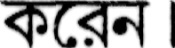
করেন।
